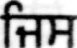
ਜਿਸ
